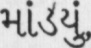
માંડયું,
